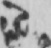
છે.
